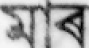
মাৰ
